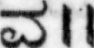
ವ||
